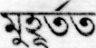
মুহূর্তত
